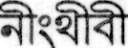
নীংথীবী
